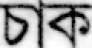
চাক
